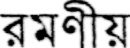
রমণীয়
